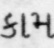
કામ
